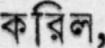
করিল,
